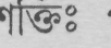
শক্তিঃ
